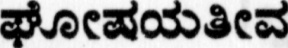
ಘೋಷಯತೀವ
